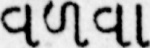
વળવા
